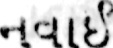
નવાઈ
